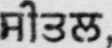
ਸੀਤਲ,
